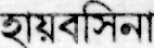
হায়বসিনা
